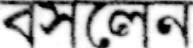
বসলেন
